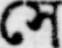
সে
